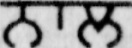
ਨਾਲ
